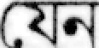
যেন
